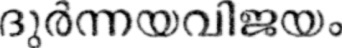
ദുര്‍ന്നയവിജയം
